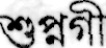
শুপ্নগী
